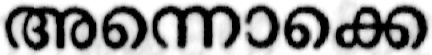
അന്നൊക്കെ
